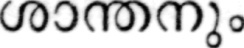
ശാന്തനും
